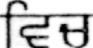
ਵਿਚ
